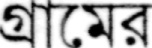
গ্রামের
